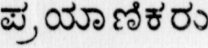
ಪ್ರಯಾಣಿಕರು
